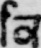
ਕਿ
